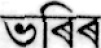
ভৰিৰ
